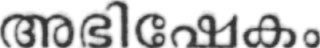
അഭിഷേകം
